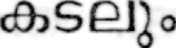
കടലും
